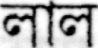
লাল
